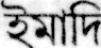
ইমাদি
